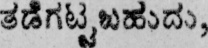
ತಡೆಗಟ್ಟಬಹುದು,
